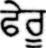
ਫੇਰੂ
